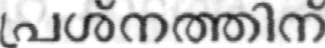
പ്രശ്നത്തിന്
